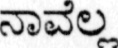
ನಾವೆಲ್ಲ
